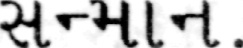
સન્માન.
